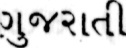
ગુજરાતી
